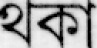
থকা
